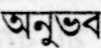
অনুভব
